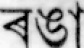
ৰঙা
